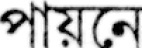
পায়নে
